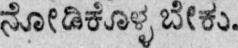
ನೋಡಿಕೊಳ್ಳಬೇಕು.
